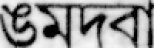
ঙমদবা
